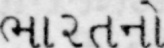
ભારતનો
